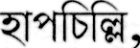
হাপচিল্লি,
